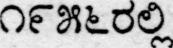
೧೯೫೬ರಲ್ಲಿ
